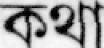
কথা
